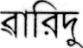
ৱারিদু
